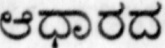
ಆಧಾರದ
